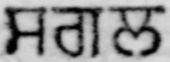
ਸਗਲ
